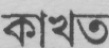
কাখত
